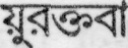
য়ুরক্তবা
